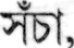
সঁচা,
